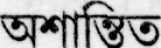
অশান্তিত
